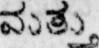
ಮತ್ತು
